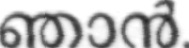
ഞാന്‍.
